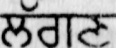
ਲੱਗਣ
